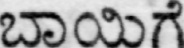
ಬಾಯಿಗೆ
